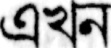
এখন
